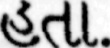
હતા.
